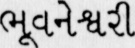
ભૂવનેશ્વરી
